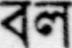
বল
